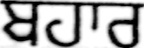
ਬਹਾਰ
